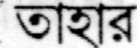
তাহার
